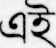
এই
